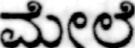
ಮೇಲೆ
